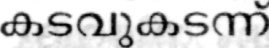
കടവുകടന്ന്
